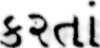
કરતાં
